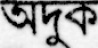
অদুক
